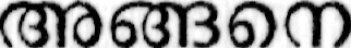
അങ്ങനെ
